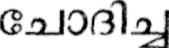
ചോദിച്ച
